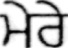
ਮੇਰੇ
